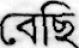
বেছি
